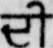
ਦੀ
